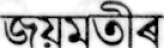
জয়মতীৰ
